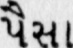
પૈસા
